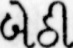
બેઠી
